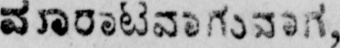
ಮಾರಾಟವಾಗುವಾಗ,
